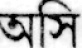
অসি
